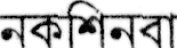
নকশিনবা
